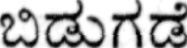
ಬಿಡುಗಡೆ
